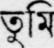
তুমি
